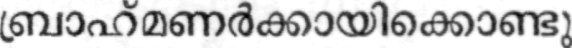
ബ്രാഹ്മണര്‍ക്കായിക്കൊണ്ടു
